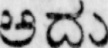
ಅದು
